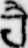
ਹੈ
